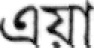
এয়া
